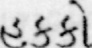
હકકો
